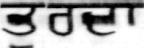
ਤੁਰਦਾ
